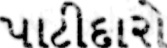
પાટીદારો
